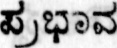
ಪ್ರಭಾವ
